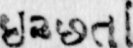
ઇચ્છતાં
